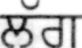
ਲੱਗ
